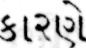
કારણે
